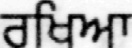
ਰਖਿਆ
